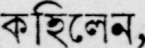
কহিলেন,
